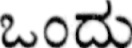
ಒಂದು
